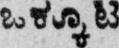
ಒಕ್ಕೂಟ
